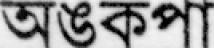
অঙকপা
